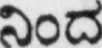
ನಿಂದ
